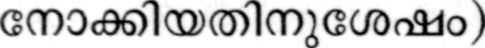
നോക്കിയതിനുശേഷം)
